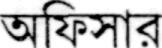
অফিসার
